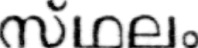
സ്ഥലം
